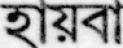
হায়বা
